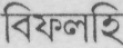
বিফলহি
